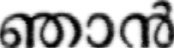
ഞാന്‍
